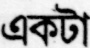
একটা
